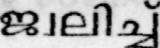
ജ്വലിച്ച്
